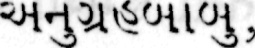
અનુગ્રહબાબુ,
